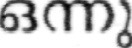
ഒന്നു
